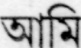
আমি
